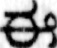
ಈ
